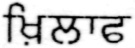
ਖ਼ਿਲਾਫ
